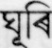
ঘূৰি
